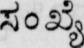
ಸಂಖ್ಯೆ
